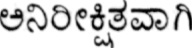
ಅನಿರೀಕ್ಷಿತವಾಗಿ
